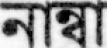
নান্বা
